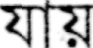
যায়
